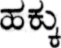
ಹಕ್ಕು
